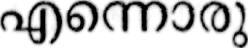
എന്നൊരു
